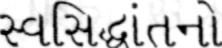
સ્વસિદ્ધાંતનો
